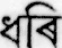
ধৰি
